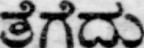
ತೆಗೆದು
